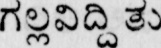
ಗಲ್ಲವಿದ್ದಿತು
